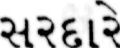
સરદારે
